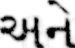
અને
